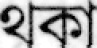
থকা
